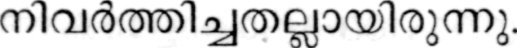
നിവര്‍ത്തിച്ചതല്ലായിരുന്നു.
